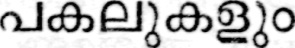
പകലുകളും
